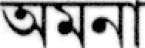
অমনা
